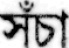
সঁচা
